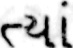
ત્યાં
